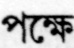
পক্ষে
